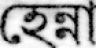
হেন্না
